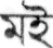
মই
